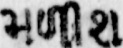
મળીશ
